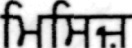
ਮਿਸਿਜ਼
